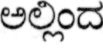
ಅಲ್ಲಿಂದ
